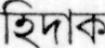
হিদাক
